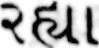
રહ્યા
